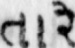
તારે
